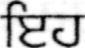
ਇਹ
